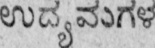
ಉದ್ಯಮಗಳ
